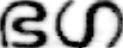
ഭഗ
